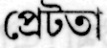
প্রেটতা
